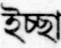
ইচ্ছা
